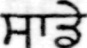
ਸਾਡੇ
